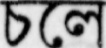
চলে
